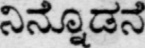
ನಿನ್ನೊಡನೆ
